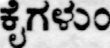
ಕೈಗಳುಂ
